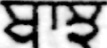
ਬਾਝ
